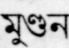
মুণ্ডন
